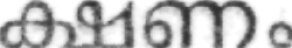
ക്ഷണം
